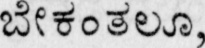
ಬೇಕಂತಲೂ,
